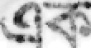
এক
